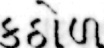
કઠોળ
